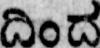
ದಿಂದ
